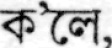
ক'লে,
